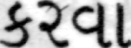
કરવા
